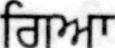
ਗਿਆ
